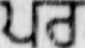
ਪਰ
